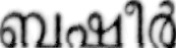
ബഷീര്‍
